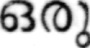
ഒരു
